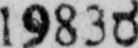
1983ರ
